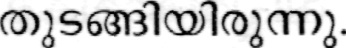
തുടങ്ങിയിരുന്നു.
